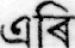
এৰি
